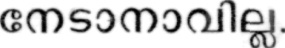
നേടാനാവില്ല.
